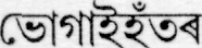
ভোগাইহঁতৰ
